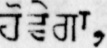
ਹੋਵੇਗਾ,
